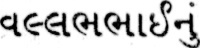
વલ્લભભાઈનું
